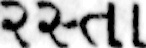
રસ્તા
